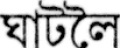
ঘাটলৈ
